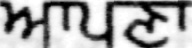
ਆਪਣਾ
